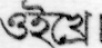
ওইখ্রে।
